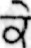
ਕੇ
